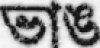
ভাঙ
